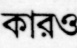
কারও
